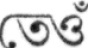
তেওঁ
